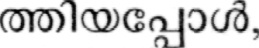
ത്തിയപ്പോള്‍,
